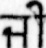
ਜੀ
